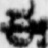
ಈ
